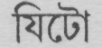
যিটো
